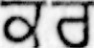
ਕਰ
